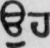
ਉਹ
